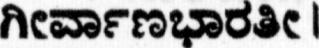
ಗೀರ್ವಾಣಭಾರತೀ|
